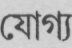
যোগ্য
